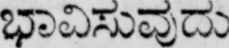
ಭಾವಿಸುವುದು
